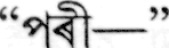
"পৰী-"
